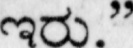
ಇರು.”
